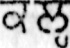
ਕਲ੍ਹ
